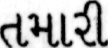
તમારી
